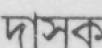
দাসক
